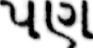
પણ
